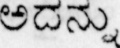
ಅದನ್ನು
